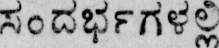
ಸಂದರ್ಭಗಳಲ್ಲಿ
